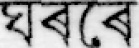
ঘৰৰে
